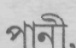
পানী,
